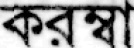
করম্বা
